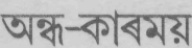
অন্ধ-কাৰময়
